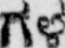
ಗಳ
